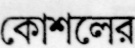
কোশলের
